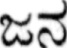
ಜನ
